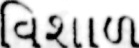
વિશાળ
